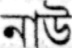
নাউ
